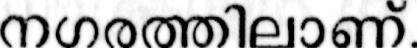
നഗരത്തിലാണ്.
